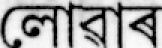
লোৱাৰ
